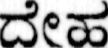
ದೇಹ
